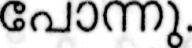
പോന്നു.
